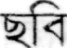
ছবি
